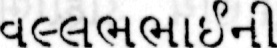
વલ્લભભાઈની
